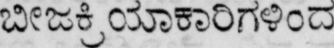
ಬೀಜಕ್ರಿಯಾಕಾರಿಗಳಿಂದ
